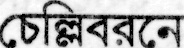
চেল্লিবরনে
